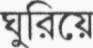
ঘুরিয়ে
